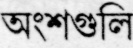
অংশগুলি
